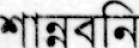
শান্নবনি
